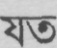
যত
